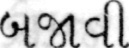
બજાવી
